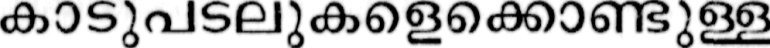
കാടുപടലുകളെക്കൊണ്ടുള്ള
